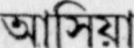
আসিয়া
